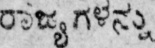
ರಾಜ್ಯಗಳನ್ನು
